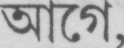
আগে,
